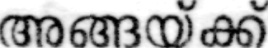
അങ്ങയ്ക്ക്
